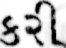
કરી
